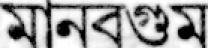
মানবগুম
